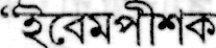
“ইবেমপীশক
